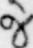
જે
